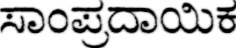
ಸಾಂಪ್ರದಾಯಿಕ
